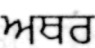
ਅਥਰ
